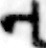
ન
